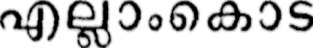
എല്ലാംകൊട
